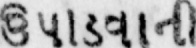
ઉપાડવાની
